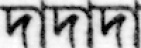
দাদাদা
